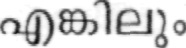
എങ്കിലും
